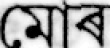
মোৰ
